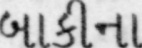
બાકીના
